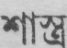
শাস্ত্ৰ
